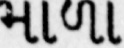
માળા
